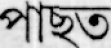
পাছত
